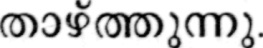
താഴ്ത്തുന്നു.
